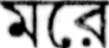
মরে
